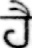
ਹੈ
